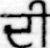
ਦੀ
